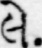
લે.
